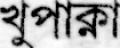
খুপাক্না
